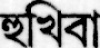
হুখিবা
